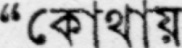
‘‘কোথায়
